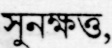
সুনক্ষত্ত,
